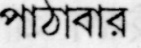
পাঠাবার
